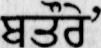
ਬਤੌਰੇ'
